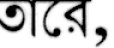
তারে,
